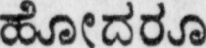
ಹೋದರೂ
